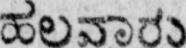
ಹಲವಾರು
